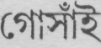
গোসাঁই
